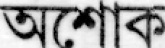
অশোক
